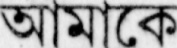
আমাকে
